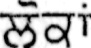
ਲੋਕਾਂ
